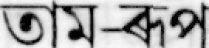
তাম-ৰূপ
